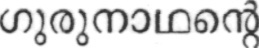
ഗുരുനാഥന്റെ
